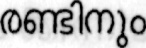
രണ്ടിനും
